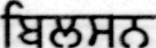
ਬਿਲਸਨ
